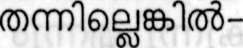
തന്നില്ലെങ്കില്‍-
